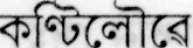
কণ্টিলৌৱে
